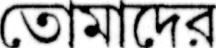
তোমাদের
